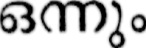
ഒന്നും
